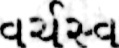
વર્ચસ્વ
